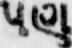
પણ
